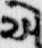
એ
